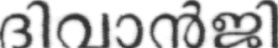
ദിവാന്‍ജി
